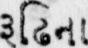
રૂઢિના
